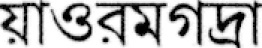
য়াওরমগদ্রা
